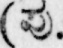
(ಪು.
